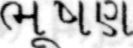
ભૂષણ
